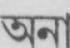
অনা
